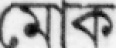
মোক
